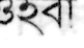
ওইবা
